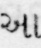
આ
